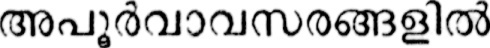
അപൂര്‍വാവസരങ്ങളില്‍
